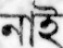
নাই
